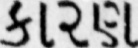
કારણ
